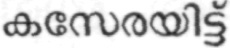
കസേരയിട്ട്
